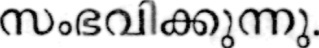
സംഭവിക്കുന്നു.
